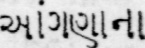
આંગણાના
